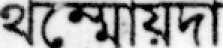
থম্মোয়দা
